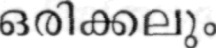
ഒരിക്കലും
